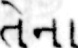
તેના
